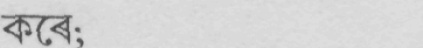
কৰে;
